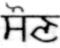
ਸੌਣ
